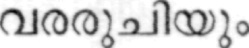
വരരുചിയും
